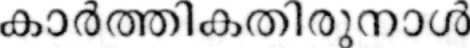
കാര്‍ത്തികതിരുനാള്‍
